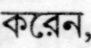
করেন,
